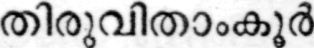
തിരുവിതാംകൂര്‍
